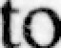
to
